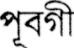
পূবগী
